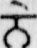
ਨੇ
